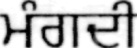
ਮੰਗਦੀ
